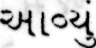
આવ્યું
